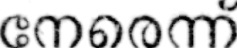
നേരെന്ന്
